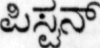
ಪಿಸ್ಟನ್
